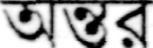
অন্তর
